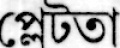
প্লেটতা
